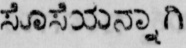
ಸೊಸೆಯನ್ನಾಗಿ
